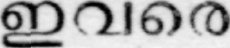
ഇവരെ
